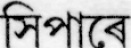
সিপাৰে
